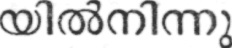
യില്‍നിന്നു
